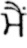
ਮੈਂ
